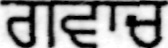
ਗਵਾਚ
